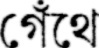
গেঁথে
